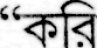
“করি
